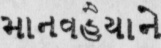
માનવહૈયાને
